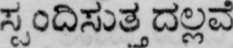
ಸ್ಪಂದಿಸುತ್ತದಲ್ಲವೆ
